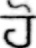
ਹੋ
